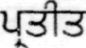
ਪ੍ਰਤੀਤ
